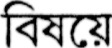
বিষয়ে
